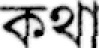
কথা
